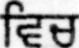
ਵਿਚ
